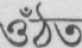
ওঁঠত
